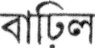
বাঢ়িল
